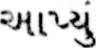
આપ્યું
